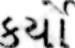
કર્યો
